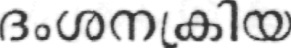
ദംശനക്രിയ
